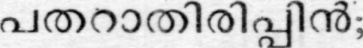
പതറാതിരിപ്പിന്‍;
